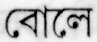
বোলে
